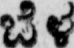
ಬೆಳ
